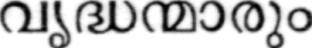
വൃദ്ധന്മാരും
